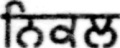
ਨਿਕਲ
